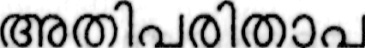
അതിപരിതാപ
